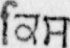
ਕਿਸ
